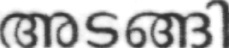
അടങ്ങി
